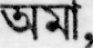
অমা,
